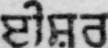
ਈਸ਼ਰ
